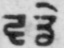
ਵਡੇ
